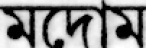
মদোম
